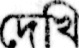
দেখি
